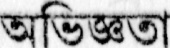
অভিজ্ঞতা
